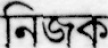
নিজক
